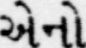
એનો
